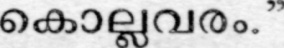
കൊല്ലവരം."
